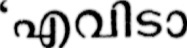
‘എവിടാ
